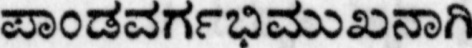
ಪಾಂಡವರ್ಗಭಿಮುಖನಾಗಿ
